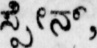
ಸ್ಪೇನ್,
